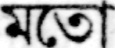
মতো
